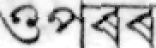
ওপৰৰ
